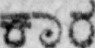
ಕಾರ
